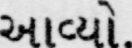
આવ્યો.
